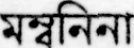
মম্বনিনা
